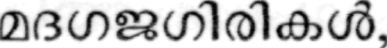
മദഗജഗിരികള്‍,
